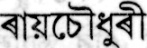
ৰায়চৌধুৰী
